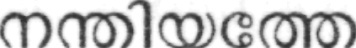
നന്തിയത്തേ
